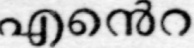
എന്റെ
